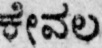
ಕೇವಲ
